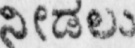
ನೀಡಲು
